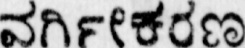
ವರ್ಗೀಕರಣ
